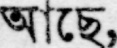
আছে,
